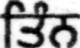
ਤਿੰਨ
